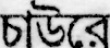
চাউরে
